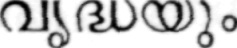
വൃദ്ധയും
